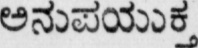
ಅನುಪಯುಕ್ತ
